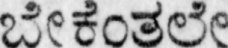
ಬೇಕೆಂತಲೇ
